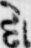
દો
